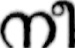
നീ
